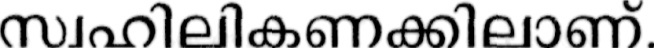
സ്വഹിലികണക്കിലാണ്.
